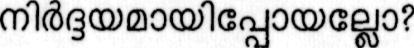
നിര്‍ദ്ദയമായിപ്പോയല്ലോ?
